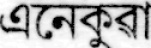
এনেকুৱা
